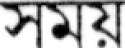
সময়
